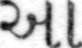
આ
